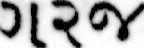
ગરજ
